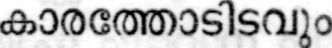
കാരത്തോടിടവും
